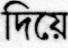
দিয়ে
